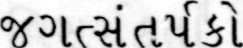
જગત્સંતર્પકો
